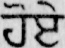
ਹੋਏ
